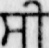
ਸੀ
